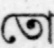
তো
